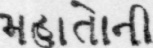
મહાતોની
